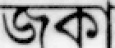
জকা
